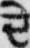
ਦੇ
